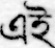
এই
